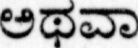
ಅಥವಾ
